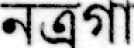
নত্রগা
